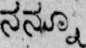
ನನ್ನೂ
